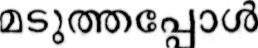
മടുത്തപ്പോള്‍
